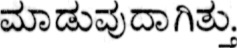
ಮಾಡುವುದಾಗಿತ್ತು.
